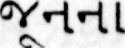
જૂનના
